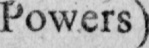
Powers)
